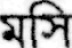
মসি
